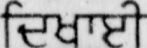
ਦਿਖਾਈ
